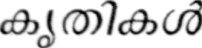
കൃതികള്‍
